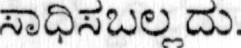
ಸಾಧಿಸಬಲ್ಲದು.
